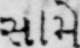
સામે
